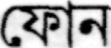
ফোন
